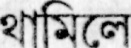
থামিলে
